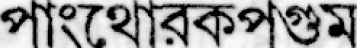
পাংথোরকপগুম
